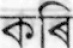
কৰি
